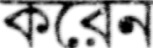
করেন
